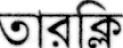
তারক্লি
